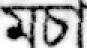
মচা
